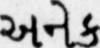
અનેક
